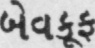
બેવકૂફ
